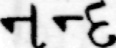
નન્દ
